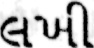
લખી
